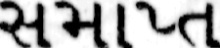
સમાપ્ત
